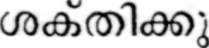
ശക്തിക്കു
